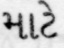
માટે
